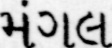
મંગલ
